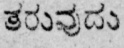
ತರುವುದು
